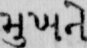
મુખને
